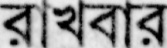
রাখবার
